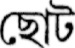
ছোট
